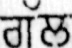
ਗੱਲ
